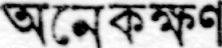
অনেকক্ষণ
